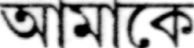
আমাকে
